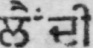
ਲੈਂਦੀ
